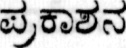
ಪ್ರಕಾಶನ
